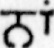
ਨਾਂ
